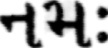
નમઃ
